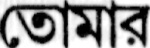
তোমার
